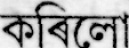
কৰিলো
